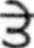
ਤੇ
